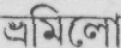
ভ্ৰমিলো
